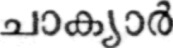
ചാക്യാര്‍
